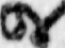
જ
